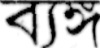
ব্যঙ্গ
